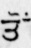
ਤੋਂ
